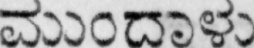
ಮುಂದಾಳು
